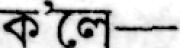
ক'লে-
